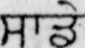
ਸਾਡੇ
